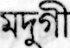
মদুগী
